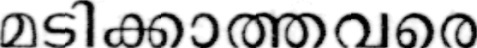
മടിക്കാത്തവരെ
